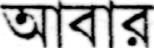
আবার
